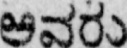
ಅವರು
